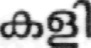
കളി
